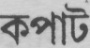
কপাট
